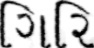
ગિરિ
